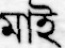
মাই
